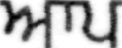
ਆਪ
